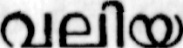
വലിയ
